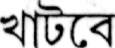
খাটবে
